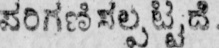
ಪರಿಗಣಿಸಲ್ಪಟ್ಟಿದೆ.
